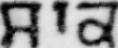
ਸਾਕ
